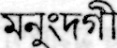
মনুংদগী
